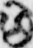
છે
